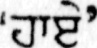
'ਹਾਏ'
